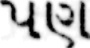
પણ
